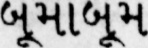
બૂમાબૂમ
